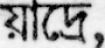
য়াদ্রে,
